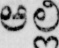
ಅಲ್ಲಿ
